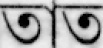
তাত
